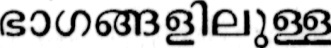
ഭാഗങ്ങളിലുള്ള
